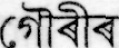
গৌৰীৰ
